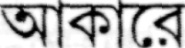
আকারে
